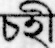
চহী
